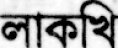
লাকখি
